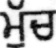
ਮੁੱਚ
